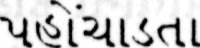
પહોંચાડતા
